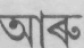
আৰু
